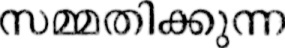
സമ്മതിക്കുന്ന
